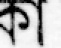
কা
